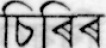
চিৰিৰ
